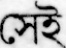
সেই
